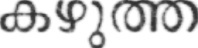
കഴുത്ത
